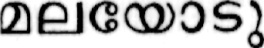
മലയോടു
